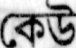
কেউ
